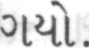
ગયો.
